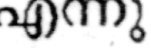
എന്നു
